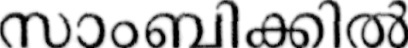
സാംബിക്കില്‍
